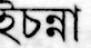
ইচন্না
